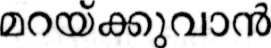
മറയ്ക്കുവാന്‍
